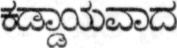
ಕಡ್ಡಾಯವಾದ
